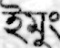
ইমুং
